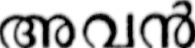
അവന്‍
